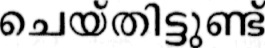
ചെയ്തിട്ടുണ്ട്
